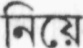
নিয়ে
